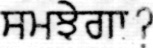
ਸਮਝੇਗਾ?
